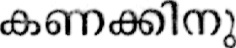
കണക്കിനു
